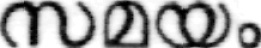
സമയം
